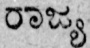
ರಾಜ್ಯ
